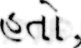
હતો,
